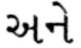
અને
